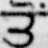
ਤੋਂ
